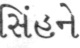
સિંહને
